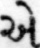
એ
